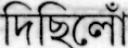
দিছিলোঁ
